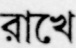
রাখে
